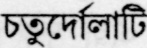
চতুর্দোলাটি
